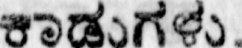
ಕಾಡುಗಳು.
